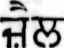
ਜ਼ੈਲ
